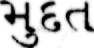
મુદત
